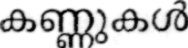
കണ്ണുകള്‍
